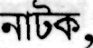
নাটক,
